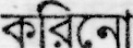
করিনো
